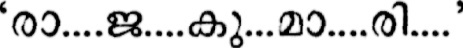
‘രാ....ജ....കു...മാ....രി....’
